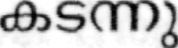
കടന്നു
